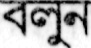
বলুন
